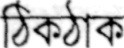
ঠিকঠাক
